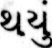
થયું
